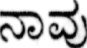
ನಾವು
